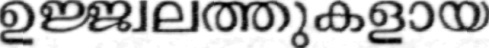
ഉജ്ജ്വലത്തുകളായ
